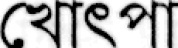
খোৎপা
